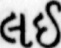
લઈ
